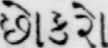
છોકરો
